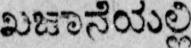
ಖಜಾನೆಯಲ್ಲಿ
